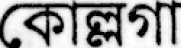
কোল্লগা
